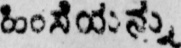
ಹಿಂಸೆಯನ್ನು
